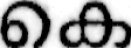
കെ
